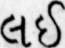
લઈ
